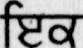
ਇਕ
